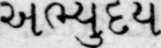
અભ્યુદય
